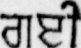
ਗਈ
